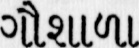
ગૌશાળા
